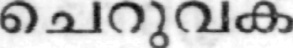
ചെറുവക
